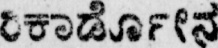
ರಿಕಾರ್ಡೋನ
